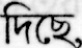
দিছে,
